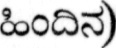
ಹಿಂದಿನ)
